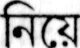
নিয়ে
